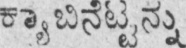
ಕ್ಯಾಬಿನೆಟ್ಟನ್ನು
